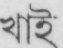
খাই
